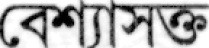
বেশ্যাসক্ত
